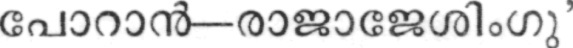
പോറാന്‍-രാജാജേശിംഗു'
